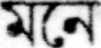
মনে
